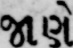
જાણે
